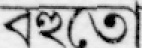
বহুতো
